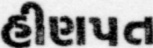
હીણપત
